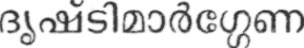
ദൃഷ്ടിമാര്‍ഗ്ഗേണ
